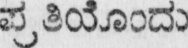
ಪ್ರತಿಯೊಂದು
